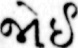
જોઈ
